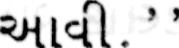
આવી."
